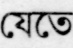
যেতে
